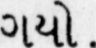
ગયો.
